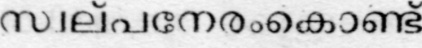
സ്വല്പനേരംകൊണ്ട്
